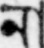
না
